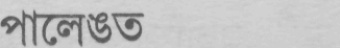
পালেঙত
